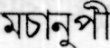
মচানুপী
